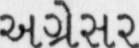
અગ્રેસર
